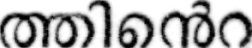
ത്തിന്റെ
